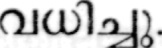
വധിച്ചു.
